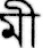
মী
